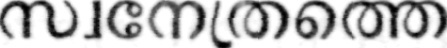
സ്വനേത്രത്തെ
